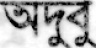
অদুবু
